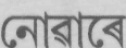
নোৱাৰে
